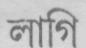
লাগি
